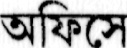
অফিসে
